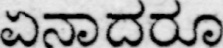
ಏನಾದರೂ
